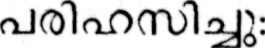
പരിഹസിച്ചു:
